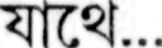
যাথে...
